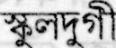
স্কুলদুগী
